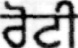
ਰੋਟੀ
